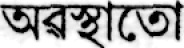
অৱস্থাতো
